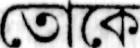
তোকে
